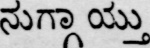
ನುಗ್ಗಾಯ್ತು
